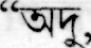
“অদু,
